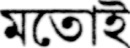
মতোই
